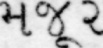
મજૂર
